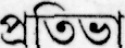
প্রতিভা
